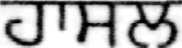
ਹਾਸਲ
